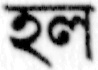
হল
